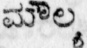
ಮೌಲ್ಯ
